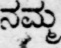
ನಮ್ಮ
